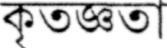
কৃতজ্ঞতা
